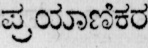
ಪ್ರಯಾಣಿಕರ
